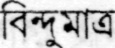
বিন্দুমাত্র
